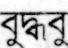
বুদ্ধবু
